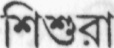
শিশুরা
